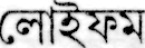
লোইফম
